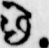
છે.
